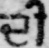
ਦੀ
